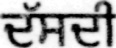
ਦੱਸਦੀ
